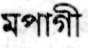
মপাগী
